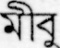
মীবু
